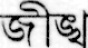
জীঙ্খ
